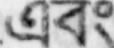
এবং
